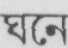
ঘনে
